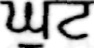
ਘੁਟ
